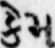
કેમ
